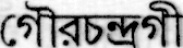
গৌরচন্দ্রগী
